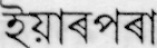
ইয়াৰপৰা
